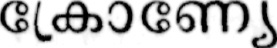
ക്രോണ്യേ
